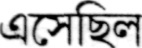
এসেছিল
